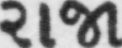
રાજા
